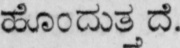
ಹೊಂದುತ್ತದೆ.
